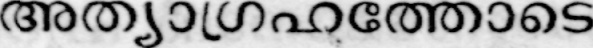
അത്യാഗ്രഹത്തോടെ
